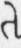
તે
